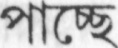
পাচ্ছে
